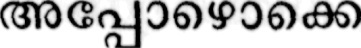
അപ്പോഴൊക്കെ
